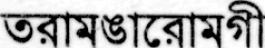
তরামঙারোমগী
